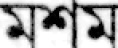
মশম
